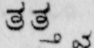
ತತ್ತ್ವ
